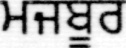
ਮਜਬੂਰ
